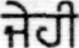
ਜੇਹੀ
